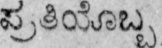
ಪ್ರತಿಯೊಬ್ಬ
